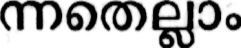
ന്നതെല്ലാം
